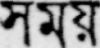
সময়
